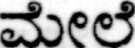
ಮೇಲೆ
